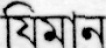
যিমান
